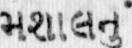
મશાલનું
